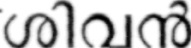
ശിവന്‍
